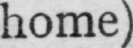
home)
